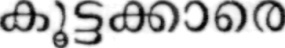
കൂട്ടക്കാരെ
